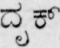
ದೃಕ್
